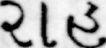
રાહ
